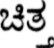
ಚಿತ್ತ
